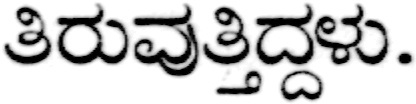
ತಿರುವುತ್ತಿದ್ದಳು.
